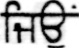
ਜਿਉਂ
